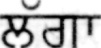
ਲੱਗਾ
